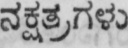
ನಕ್ಷತ್ರಗಳು
